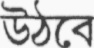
উঠবে
